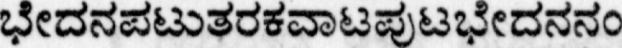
ಭೇದನಪಟುತರಕವಾಟಪುಟಭೇದನನಂ
